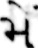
મેં
